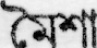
মৈশা
